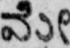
ಮೇ
